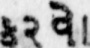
કરવો
